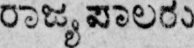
ರಾಜ್ಯಪಾಲರು
